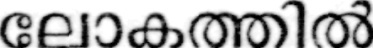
ലോകത്തില്‍
